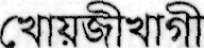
খোয়জীখাগী
